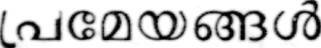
പ്രമേയങ്ങള്‍
